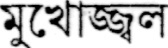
মুখোজ্জ্বল
